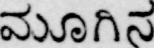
ಮೂಗಿನ
